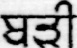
ਬੜੀ
